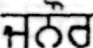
ਜਨੌਰ
